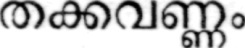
തക്കവണ്ണം
